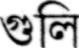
গুলি
